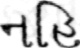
નહિ
